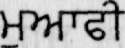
ਮੁਆਫੀ
